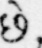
છે,
